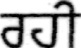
ਰਹੀ
